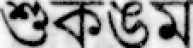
শুকঙম
